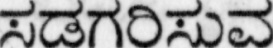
ಸಡಗರಿಸುವ
